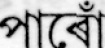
পাৰোঁ
